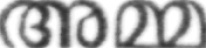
അമ്മ
